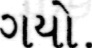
ગયો.
